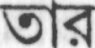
তার
